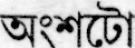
অংশটো
